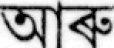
আৰু
